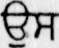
ਉਸ
